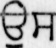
ਉਸ
